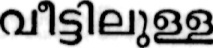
വീട്ടിലുള്ള
